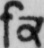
ਕਿ
